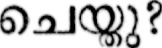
ചെയ്തു?
